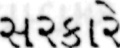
સરકારે
